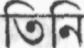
তিনি
